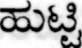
ಹುಟ್ಟಿ
